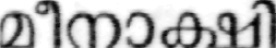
മീനാക്ഷി
